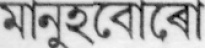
মানুহবোৰো
